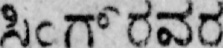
ಸಿಂಗ್ರವರ
